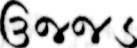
ઉજ્જડ
